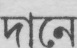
দানে
